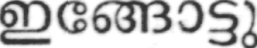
ഇങ്ങോട്ടു
